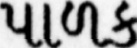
પાળક
